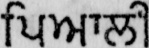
ਪਿਆਲੀ
